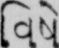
વિષે
